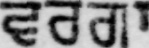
ਵਰਗਾ
